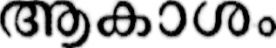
ആകാശം
